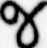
જ
